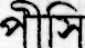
পীসি
